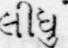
લીધું
